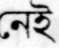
নেই
